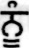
ਨੂੰ
